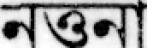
নত্তনা
